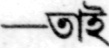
–তাই
